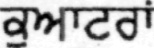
ਕੁਆਟਰਾਂ
